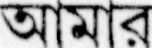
আমার
